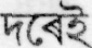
দৰেই
